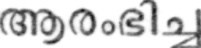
ആരംഭിച്ച
